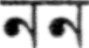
নন
